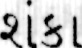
શંકા
